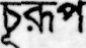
চূরূপ
